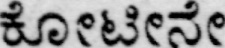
ಕೋಟೀನೇ
